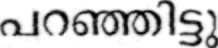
പറഞ്ഞിട്ടു
